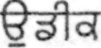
ਉਡੀਕ
